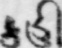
કહી
